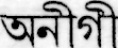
অনীগী
